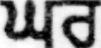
ਘਰ
